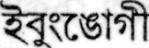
ইবুংঙোগী
